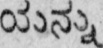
ಯನ್ನು
